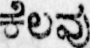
ಕೆಲವು
